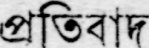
প্রতিবাদ
